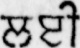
ਲਈ
